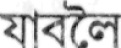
যাবলৈ
